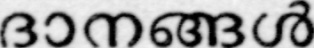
ദാനങ്ങള്‍
